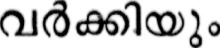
വര്‍ക്കിയും
